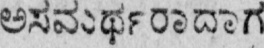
ಅಸಮರ್ಥರಾದಾಗ
